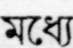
মধ্যে
